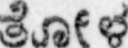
ತೋಳ
